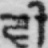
ਵੀ
